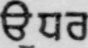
ਉਧਰ
